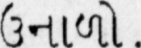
ઉનાળો.
